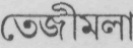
তেজীমলা
